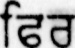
ਫਿਰ
